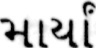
માર્યાં
